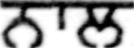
ਨਾਲ
